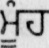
ਮੂੰਹ
